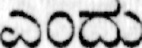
ಎಂದು
